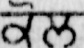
ਕੋਲ
